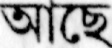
আছে
